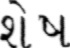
શેષ
